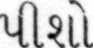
પીશો
